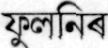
ফুলনিৰ
